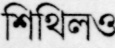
শিথিলও
